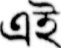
এই
